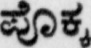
ಪೊಕ್ಕ
